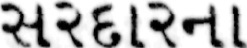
સરદારના
